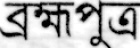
ব্রহ্মপুত্র
